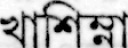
খাশিন্না
